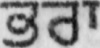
ਭਰਾ
